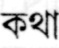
কথা
